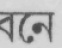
বনে
